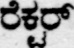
ರೆಕ್ಟರ್
